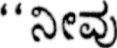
"ನೀವು
